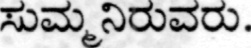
ಸುಮ್ಮನಿರುವರು.
